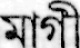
মাগী
